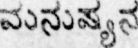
ಮನುಷ್ಯನ
